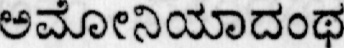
ಅಮೋನಿಯಾದಂಥ
